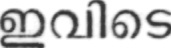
ഇവിടെ
